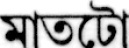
মাতটো
